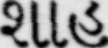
શાહ
